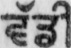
ਵੱਡੀ
